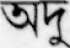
অদু
